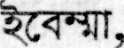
ইবেম্মা,
